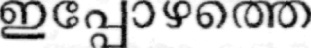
ഇപ്പോഴത്തെ
